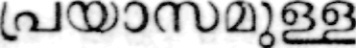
പ്രയാസമുള്ള
